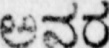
ಅವರ
